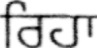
ਰਿਹਾ
